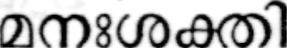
മനഃശക്തി
